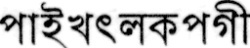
পাইখৎলকপগী
